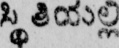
ಸ್ಥಿತಿಯಲ್ಲಿ
